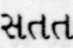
સતત
